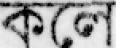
কলে
